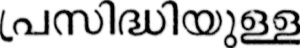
പ്രസിദ്ധിയുള്ള
